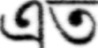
এত
